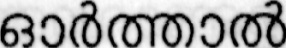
ഓര്‍ത്താല്‍
